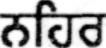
ਨਹਿਰ
